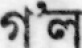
গ'ল
